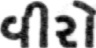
વીરો
